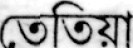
তেতিয়া
